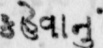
કહેવાનું
